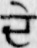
ਦੇ
